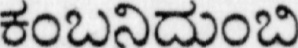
ಕಂಬನಿದುಂಬಿ
